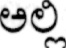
ಅಲ್ಲಿ
